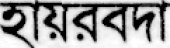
হায়রবদা
